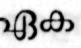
ഏക
